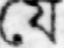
যে
